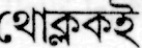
থোক্লকই
